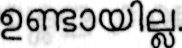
ഉണ്ടായില്ല.
